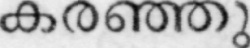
കരഞ്ഞു
